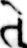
તે
